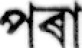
পৰা
